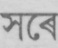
সৰে
